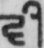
ਵੀ
